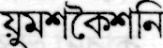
য়ুমশকৈশানি
